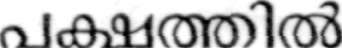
പക്ഷത്തില്‍
